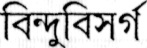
বিন্দুবিসর্গ
